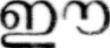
ഈ
